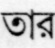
তার
